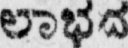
ಲಾಭದ
